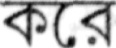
করে
